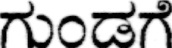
ಗುಂಡಗೆ
